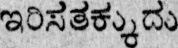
ಇರಿಸತಕ್ಕುದು
